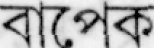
বাপেক
